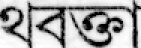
থবক্তা
